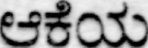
ಆಕೆಯ
